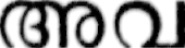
അവ
